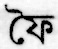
ফৈ
